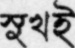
সুখই
